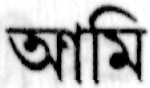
আমি
